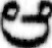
ಆ
